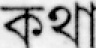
কথা
